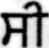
ਸੀ
